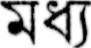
মধ্য
